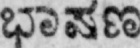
ಭಾಷಣ
